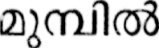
മുമ്പില്‍
